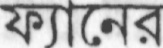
ফ্যানের
